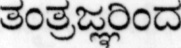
ತಂತ್ರಜ್ಞರಿಂದ
